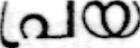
പ്രയ
